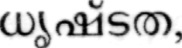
ധൃഷ്ടത,
